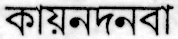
কায়নদনবা
